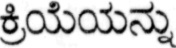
ಕ್ರಿಯೆಯನ್ನು
